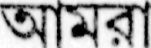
আমরা
